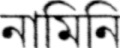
নামিনি
